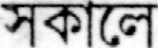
সকালে
